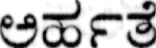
ಅರ್ಹತೆ
